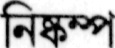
নিষ্কম্প
